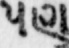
પણ
